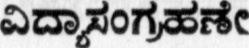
ವಿದ್ಯಾಸಂಗ್ರಹಣೇ
